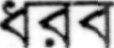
ধরব
